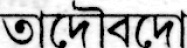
তাদৌবদো
